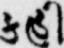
કહી
